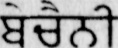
ਬੇਚੈਨੀ
